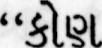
"કોણ
